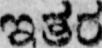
ಇತರ
